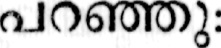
പറഞ്ഞു:
